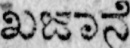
ಖಜಾನೆ
